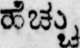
ಹೆಚ್ಚು
